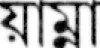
য়াম্না
